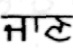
ਜਾਣ
